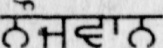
ਨੌਜਵਾਨ
